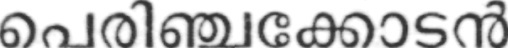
പെരിഞ്ചക്കോടന്‍
